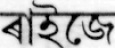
ৰাইজে
